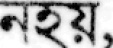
নহয়,
